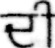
ਦੀ
